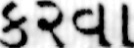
કરવા
